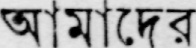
আমাদের
